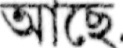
আছে
